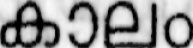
കാലം
